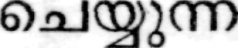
ചെയ്യുന്ന
